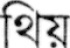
থিয়
